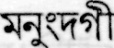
মনুংদগী
